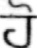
ਹੋ
